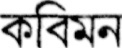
কবিমন
